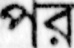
পর
